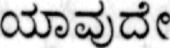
ಯಾವುದೇ
